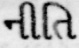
નીતિ
